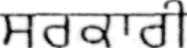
ਸਰਕਾਰੀ
